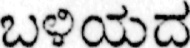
ಬಳಿಯದ
